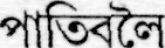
পাতিবলৈ
